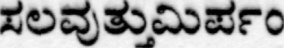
ಸಲವುತ್ತುಮಿರ್ಪಂ
